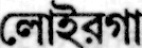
লোইরগা
